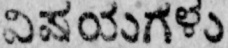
ವಿಷಯಗಳು
